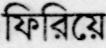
ফিরিয়ে
